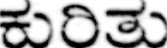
ಕುರಿತು
